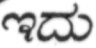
ಇದು
